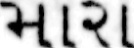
મારા
